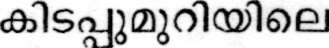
കിടപ്പുമുറിയിലെ
